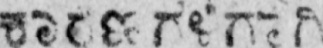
ಕಾರಣಗಳಿಗಾಗಿ
